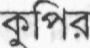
কুপির
